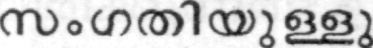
സംഗതിയുള്ളു
